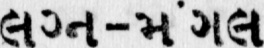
લગ્ન-મંગલ
